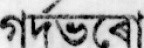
গর্দভৰো
